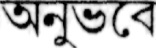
অনুভবে
